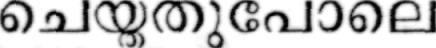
ചെയ്തതുപോലെ
